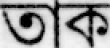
তাক
